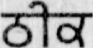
ਠੀਕ
